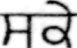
ਸਕੇ
